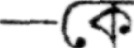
–কে
